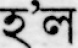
হ'ল
